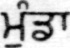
ਮੁੰਡਾ
